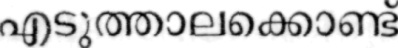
എടുത്താലക്കൊണ്ട്
